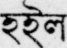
হইল
